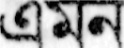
এমন
